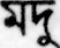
মদু
